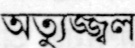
অত্যুজ্জ্বল
